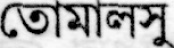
তোমালসু
